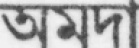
অমদা
